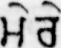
ਮੇਰੇ
